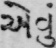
એવું
